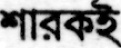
শারকই
